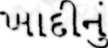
ખાદીનું
